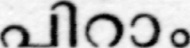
പിറാം
